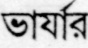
ভার্যার
